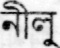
নীলু
